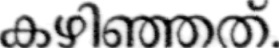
കഴിഞ്ഞത്.
